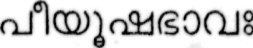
പീയുഷഭാവഃ
